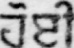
ਹੋਈ
